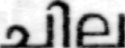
ചില
